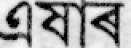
এষাৰ
